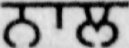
ਨਾਲ
